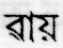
ৱায়
